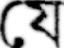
যে
